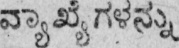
ವ್ಯಾಖ್ಯೆಗಳನ್ನು
